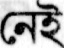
নেই
